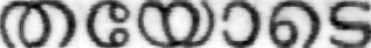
തയോടെ
